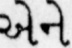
એને
